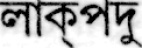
লাক্পদু
